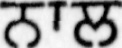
ਨਾਲ
